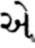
એ
